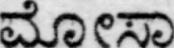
ಮೋಸಾ
